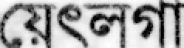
য়েৎলগা
